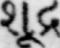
શૂદ્ર
